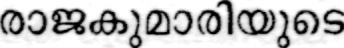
രാജകുമാരിയുടെ
